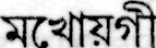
মখোয়গী
